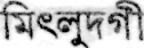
মিৎলুদগী
